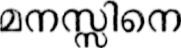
മനസ്സിനെ
